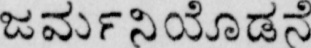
ಜರ್ಮನಿಯೊಡನೆ
